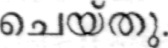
ചെയ്തു.
